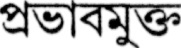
প্রভাবমুক্ত
